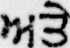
ਅਤੇ
